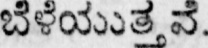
ಬೆಳೆಯುತ್ತವೆ.
